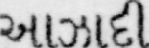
આઝાદી
